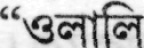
"ওলালি
